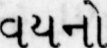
વયનો
